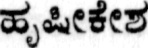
ಹೃಷೀಕೇಶ
